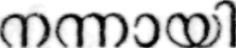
നന്നായി
